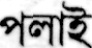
পলাই
